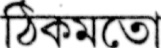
ঠিকমতো
